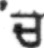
'ਚ
